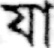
যা
